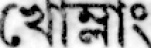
খোম্লাং
